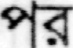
পর
